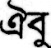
ঐবু
